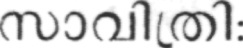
സാവിത്രി:
